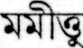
মমীত্তু
